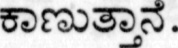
ಕಾಣುತ್ತಾನೆ.
